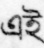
এই
